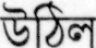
উঠিল
